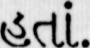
હતાં.
